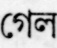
গেল
